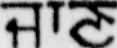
ਜਾਣ
